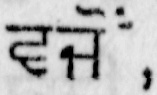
ਵਜੋਂ,
